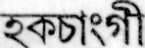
হকচাংগী
